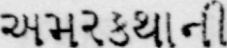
અમરકથાની
